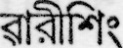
ৱারীশিং
